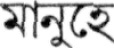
মানুহে
